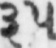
રૂપ
